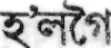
হ'লগৈ
